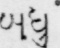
બધું
